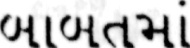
બાબતમાં
